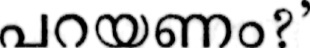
പറയണം?’
